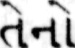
તેનો
